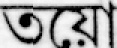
তয়ো
